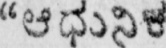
“ಆಧುನಿಕ
